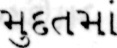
મુદતમાં
